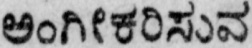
ಅಂಗೀಕರಿಸುವ
